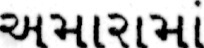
અમારામાં
